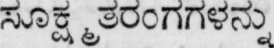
ಸೂಕ್ಷ್ಮತರಂಗಗಳನ್ನು
